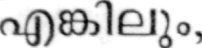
എങ്കിലും,
